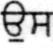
ਉਸ
